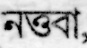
নত্তবা,
